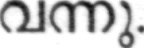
വന്നു.
